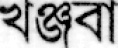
খঞ্জবা
